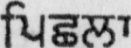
ਪਿਛਲਾ
